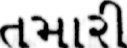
તમારી
